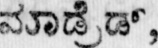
ಮಾಡ್ರೆಡ್,
